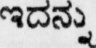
ಇದನ್ನು
